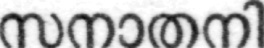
സനാതനി
